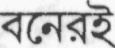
বনেরই
